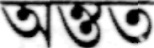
অন্তত
